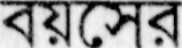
বয়সের
